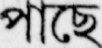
পাছে
